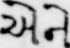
એને
